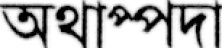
অথাপ্পদা
